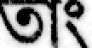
তাং
